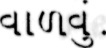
વાળવું.
